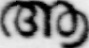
ആ
